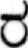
ರ
